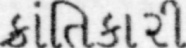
ક્રાંતિકારી
